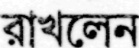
রাখলেন
